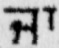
ਜਾ
